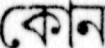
কোন
